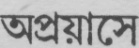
অপ্ৰয়াসে
